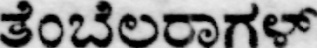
ತೆಂಬೆಲರಾಗಳ್
